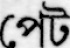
পেট
